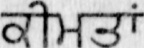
ਕੀਮਤਾਂ
